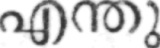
എന്തു
